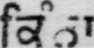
ਕਿੰਨਾ
